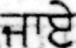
ਜਾਏ
